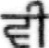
ਵੀ
